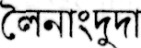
লৈনাংদুদা
